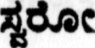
ಸ್ವರೋ
